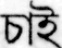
চাই
